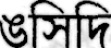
ঙসিদি
